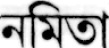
নমিতা
